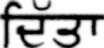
ਦਿੱਤਾ
